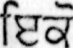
ਇਕੋ
